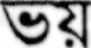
ভয়
